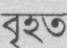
বৃহত
